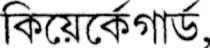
কিয়ের্কেগার্ড,
